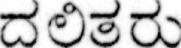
ದಲಿತರು
